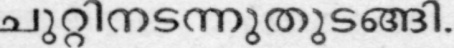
ചുറ്റിനടന്നുതുടങ്ങി.
